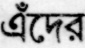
এঁদের
